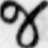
જ
